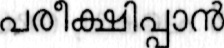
പരീക്ഷിപ്പാന്‍
